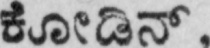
ಕೋಡಿನ್,
